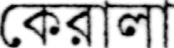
কেরালা
